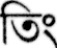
তিং
